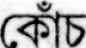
কোঁচ
